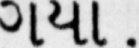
ગયા.
